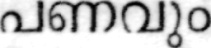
പണവും
